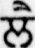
ਲੈ
